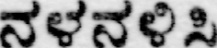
ನಳನಳಿಸಿ
